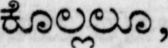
ಕೊಲ್ಲಲೂ,
